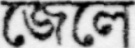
জেলে
